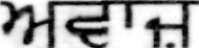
ਅਵਾਜ਼
